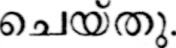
ചെയ്തു.
